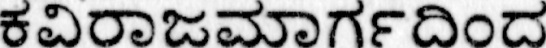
ಕವಿರಾಜಮಾರ್ಗದಿಂದ
